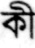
কী
